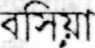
বসিয়া
